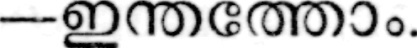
-ഇന്തത്തോം.
